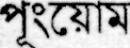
পূংয়োম
